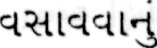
વસાવવાનું
